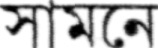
সামনে
